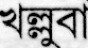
খল্লুবা
